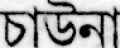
চাউনা
